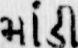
માંડી
